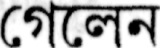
গেলেন
